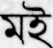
মই
